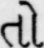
તો
